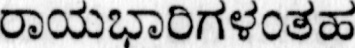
ರಾಯಭಾರಿಗಳಂತಹ
